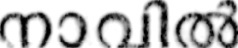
നാവില്‍
